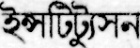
ইন্সটিট্যুসন
